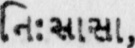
નિઃસાસા,
